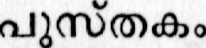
പുസ്തകം
